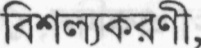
বিশল্যকরণী,
